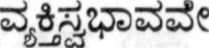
ವ್ಯಕ್ತಿಸ್ವಭಾವವೇ
